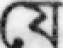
যে
